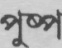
পুষ্প
